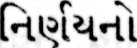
નિર્ણયનો
